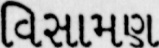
વિસામણ
